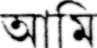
আমি
